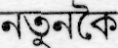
নতুনকৈ
